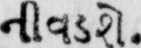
નીવડશે.
